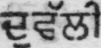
ਦੁਵੱਲੀ
